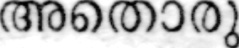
അതൊരു
